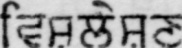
ਵਿਸ਼ਲੇਸ਼ਣ
